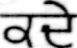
ਕਦੇ
